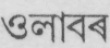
ওলাবৰ
